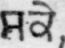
ਸਕੇ,
